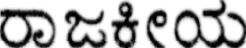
ರಾಜಕೀಯ
